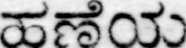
ಹಣೆಯ
